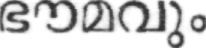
ഭൗമവും
